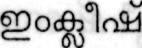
ഇംക്ലീഷ്
